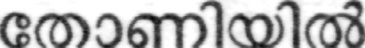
തോണിയില്‍
